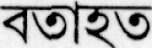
বতাহত
